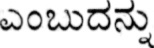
ಎಂಬುದನ್ನು
